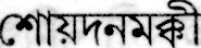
শোয়দনমক্কী
